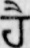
ਹੈ
